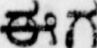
ಈಗ
